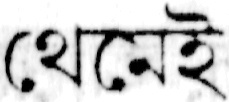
থেমেই
